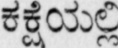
ಕಕ್ಷೆಯಲ್ಲಿ
